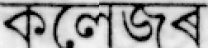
কলেজৰ
